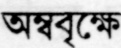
অম্ববৃক্ষে
